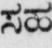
ಸಹ
